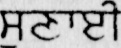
ਸੁਣਾਈ
